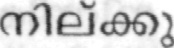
നില്ക്കു
